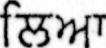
ਲਿਆ
